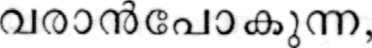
വരാന്‍പോകുന്ന,
